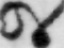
જ
